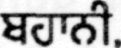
ਬਹਾਨੀ,
